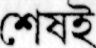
শেষই
